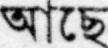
আছে
